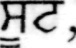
ਸੂਟ,
